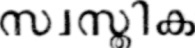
സ്വസ്തിക
